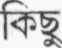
কিছু
